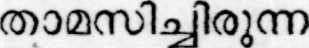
താമസിച്ചിരുന്ന
